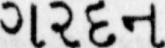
ગરદન
